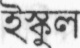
ইস্কুল
